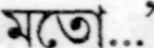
মতো...’
